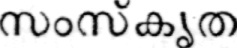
സംസ്കൃത
